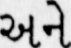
અને
